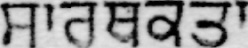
ਸਾਰਥਕਤਾ
